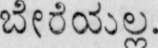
ಬೇರೆಯಲ್ಲ.
